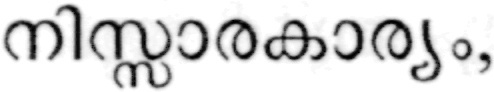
നിസ്സാരകാര്യം,
